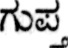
ಗುಪ್ತ
